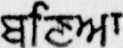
ਬਣਿਆ
